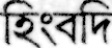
হিংবদি
